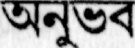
অনুভব
